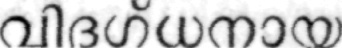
വിദഗ്ധനായ
